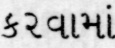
કરવામાં
